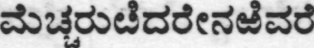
ಮೆಚ್ಚರುೞಿದರೇನೞಿವರೆ
